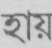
হায়
